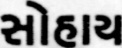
સોહાય
